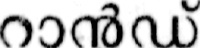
റാന്‍ഡ്
